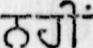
ਨਹੀਂ
